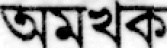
অমখক
